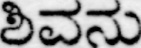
ಶಿವನು
